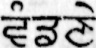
ਵੰਡਣੇ
